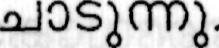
ചാടുന്നു.
